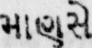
માણસે
